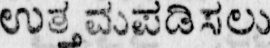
ಉತ್ತಮಪಡಿಸಲು
